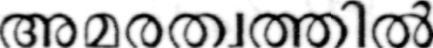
അമരത്വത്തില്‍
